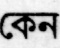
কেন
